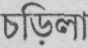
চড়িলা
